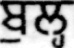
ਬੁਲ੍ਹ
